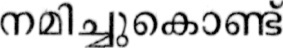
നമിച്ചുകൊണ്ട്
